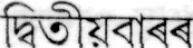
দ্বিতীয়বাৰৰ
